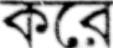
করে
